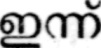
ഇന്ന്
